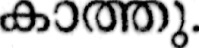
കാത്തു.
